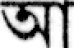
আ
